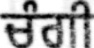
ਚੰਗੀ
